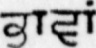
ਭਾਵਾਂ
